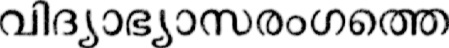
വിദ്യാഭ്യാസരംഗത്തെ
